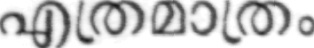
എത്രമാത്രം
